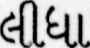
લીધા
